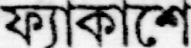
ফ্যাকাশে
